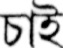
চাই
